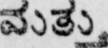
ಮತ್ತು
